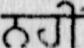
ਨਹੀਂ
